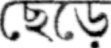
ছেড়ে
